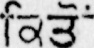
ਕਿਤੋਂ
